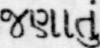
જણાતું
